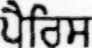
ਪੈਰਿਸ
